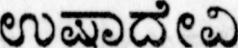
ಉಷಾದೇವಿ
